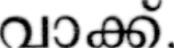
വാക്ക്.
